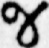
જ
